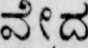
ವೇದ
